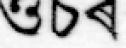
ওচৰ
